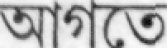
আগতে
